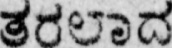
ತರಲಾದ
